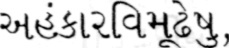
અહંકારવિમૂઢેષુ,
